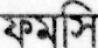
ফমসি
